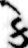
કે
